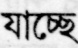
যাচ্ছে
